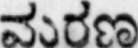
ಮರಣ
